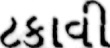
ટકાવી
